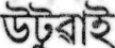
উটুৱাই
